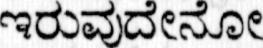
ಇರುವುದೇನೋ
